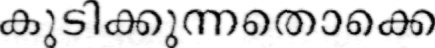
കുടിക്കുന്നതൊക്കെ
